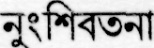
নুংশিবতনা
